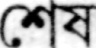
শেষ
